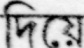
দিয়ে
